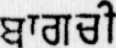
ਬਾਗਚੀ
